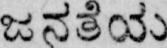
ಜನತೆಯ
